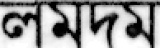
লমদম
